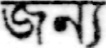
জন্য
